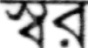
স্বর
